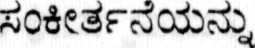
ಸಂಕೀರ್ತನೆಯನ್ನು
